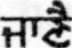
ਜਾਣੈ
